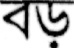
বড়
